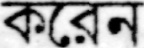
করেন
